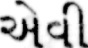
એવી
